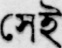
সেই
